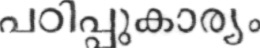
പഠിപ്പുകാര്യം
